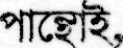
পান্থোই,
